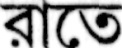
রাতে
